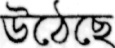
উঠেছে
